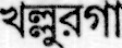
খল্লুরগা
